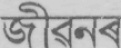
জীৱনৰ
